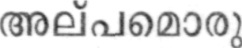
അല്പമൊരു
